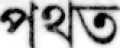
পথত
